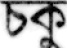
চকু
